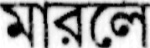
মারলে
